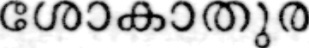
ശോകാതുര
